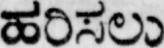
ಹರಿಸಲು
